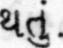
થતું.
